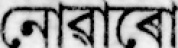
নোৱাৰো
